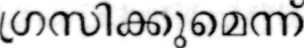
ഗ്രസിക്കുമെന്ന്
